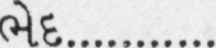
ભેદ...........
